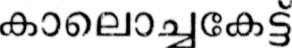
കാലൊച്ചകേട്ട്
